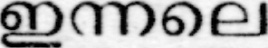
ഇന്നലെ
